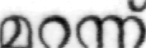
മറന്ന്
